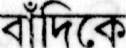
বাঁদিকে
